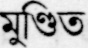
মুণ্ডিত
